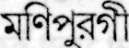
মণিপুরগী
